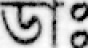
ডাঃ
